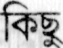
কিছু
